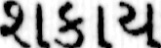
શકાય
